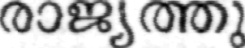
രാജ്യത്തു
